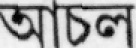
আচল
